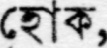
হোক,
